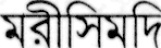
মরীসিমদি
